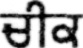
ਚੀਕ
